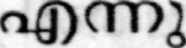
എന്നു
